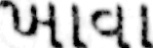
ખાવા
